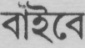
বাইবে
